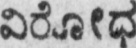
ವಿರೋಧ
